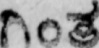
ಗಿಂತ
